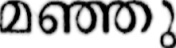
മഞ്ഞു
